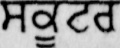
ਸਕੂਟਰ
